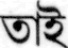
তাই
